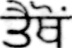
ਤੈਥੋਂ
